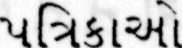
પત્રિકાઓ
